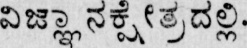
ವಿಜ್ಞಾನಕ್ಷೇತ್ರದಲ್ಲಿ.
